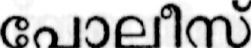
പോലീസ്
